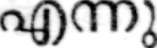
എന്നു
